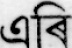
এৰি
